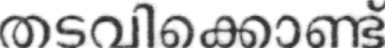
തടവിക്കൊണ്ട്
